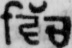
ਵਿੱਚ
